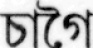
চাগৈ
